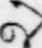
જે
